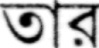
তার
